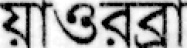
য়াওরব্রা
